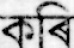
কৰি
